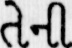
તેની
